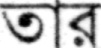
তার
